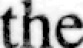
the
